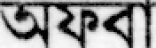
অফবা
